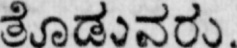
ತೊಡುವರು.
